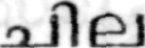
ചില
